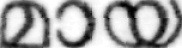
മായ
